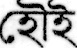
হৌই
